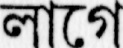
লাগে
